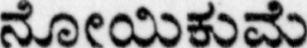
ನೋಯಿಕುಮೆ
